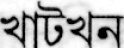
খাটখন
